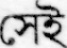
সেই
